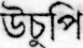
উচুপি
